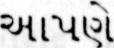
આપણે
